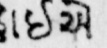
હોઈ
